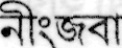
নীংজবা
